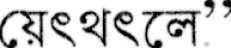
য়েৎথৎলে”
